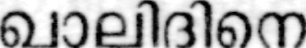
ഖാലിദിനെ
